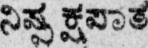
ನಿಷ್ಪಕ್ಷಪಾತ
